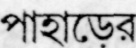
পাহাড়ের
